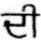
ਦੀ
